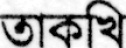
তাকখি
